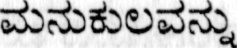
ಮನುಕುಲವನ್ನು
